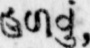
હળવું,
